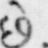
છે.
